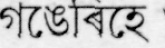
গঙেৰিহে
